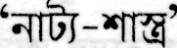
‘নাট্য-শাস্ত্র’
